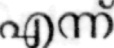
എന്ന്
